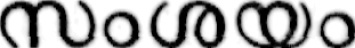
സംശയം
